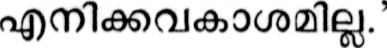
എനിക്കവകാശമില്ല.’
